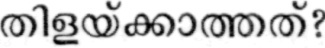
തിളയ്ക്കാത്തത്?
